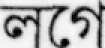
লগে
